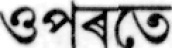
ওপৰতে
